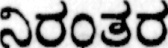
ನಿರಂತರ
